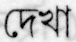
দেখা
